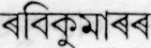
ৰবিকুমাৰৰ
